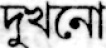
দুখনো
